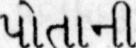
પોતાની
